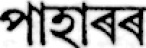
পাহাৰৰ
